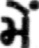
મેં
